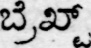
ಬ್ರೆಖ್ಟ್
